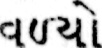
વળ્યો
